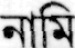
নামি
